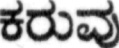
ಕರುವು
